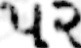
પર
